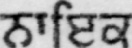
ਨਾਇਕ
